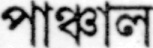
পাঞ্চাল
